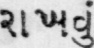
રાખવું
